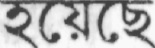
হয়েছে
